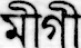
মীগী
